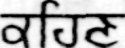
ਕਹਿਣ
